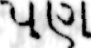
પણ
